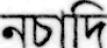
নচাদি
